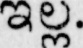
ಇಲ್ಲ.
